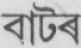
বাটৰ
